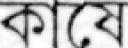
কাষে
